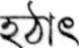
হঠাৎ
